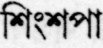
শিংশপা
